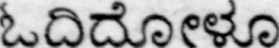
ಓದಿದೋಳೂ
